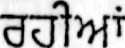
ਰਹੀਆਂ
